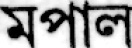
মপাল
